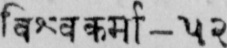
પર
